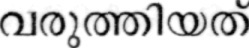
വരുത്തിയത്
